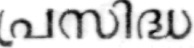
പ്രസിദ്ധ
